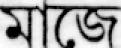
মাজে
